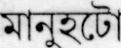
মানুহটো
